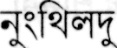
নুংথিলদু
